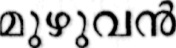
മുഴുവന്‍
